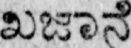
ಖಜಾನೆ
